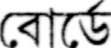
বোর্ডে
